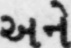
અને
